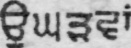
ਉਘੜਵਾਂ
